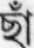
ছাঁ
